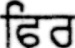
ਫਿਰ
